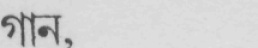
গান,
